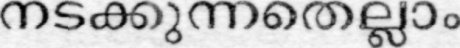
നടക്കുന്നതെല്ലാം
